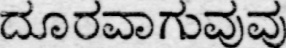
ದೂರವಾಗುವುವು
